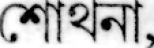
শোথনা,
